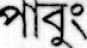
পাবুং
